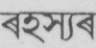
ৰহস্যৰ
